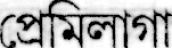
প্রেমিলাগা
